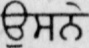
ਉਸਨੇ
